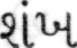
શંખ
